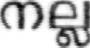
നല്ല
